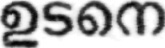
ഉടനെ
